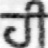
ਹੀ
